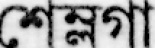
শেম্লগা
